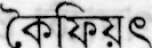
কৈফিয়ৎ
